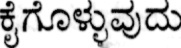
ಕೈಗೊಳ್ಳುವುದು
